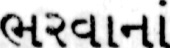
ભરવાનાં
